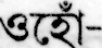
ওহোঁ-
